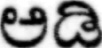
ಅಡಿ
